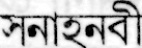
সনাহনবী
